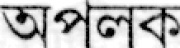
অপলক
